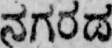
ನಗರದ
